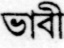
ভাবী
